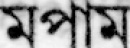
মপাম
